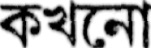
কখনো
